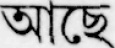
আছে
